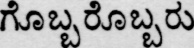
ಗೊಬ್ಬರೊಬ್ಬರು
